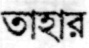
তাহার
